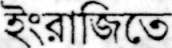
ইংরাজিতে
